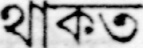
থাকত
